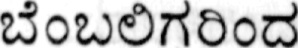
ಬೆಂಬಲಿಗರಿಂದ
